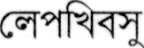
লেপখিবসু
